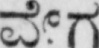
ವೇಗ
